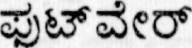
ಫುಟ್‌ವೇರ್
